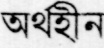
অর্থহীন
